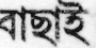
বাছাই
